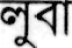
লুবা
